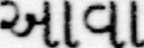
આવા
